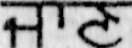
ਜਾਣ
